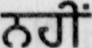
ਨਹੀਂ
